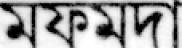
মফমদা
